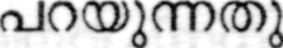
പറയുന്നതു
